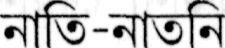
নাতি-নাতনি
